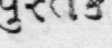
પુસ્તક
